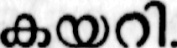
കയറി.
